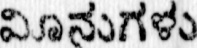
ಮೀನುಗಳು
